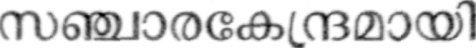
സഞ്ചാരകേന്ദ്രമായി
